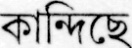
কান্দিছে
